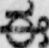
ಈ
